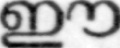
ഈ
